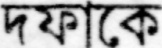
দফাকে
